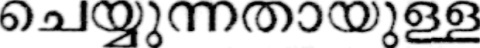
ചെയ്യുന്നതായുള്ള
